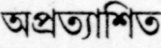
অপ্রত্যাশিত
